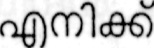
എനിക്ക്
